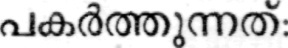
പകര്‍ത്തുന്നത്:
